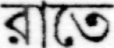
রাতে
